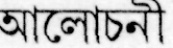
আলোচনী
